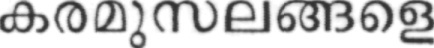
കരമുസലങ്ങളെ
